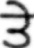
ਤੇ
